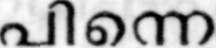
പിന്നെ
